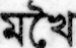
মখৈ
